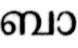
ബാ
